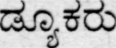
ಡ್ಯೂಕರು
